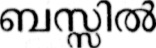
ബസ്സില്‍
